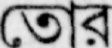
তোর
